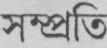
সম্প্ৰতি
